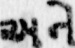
અને
